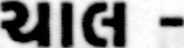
ચાલ-
